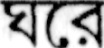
ঘরে
